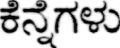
ಕೆನ್ನೆಗಳು
